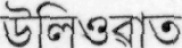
উলিওৱাত
